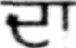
ਦਾ
